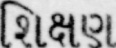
શિક્ષણ
